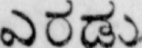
ಎರಡು
